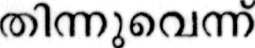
തിന്നുവെന്ന്
